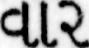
વાર
